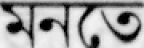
মনতে
